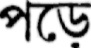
পড়ে
